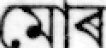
মোৰ
